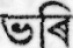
ভৰি
